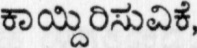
ಕಾಯ್ದಿರಿಸುವಿಕೆ,
